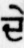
ਦੇ
